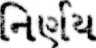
નિર્ણય
